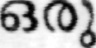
ഒരു
